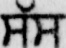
ਸੱਸ
